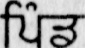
ਪਿੰਡ
